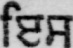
ਇਸ
